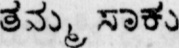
ತಮ್ಮಸಾಕು
